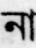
না
